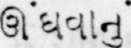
ઊંઘવાનું
